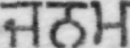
ਜਨਮ
